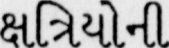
ક્ષત્રિયોની
